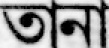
তানা
